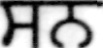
ਸਨ
